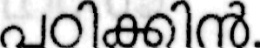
പഠിക്കിന്‍.
